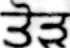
ਤੋੜ
